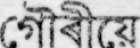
গৌৰীয়ে
